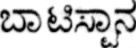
ಬಾಟಿಸ್ಪಾನ
